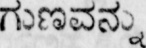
ಗುಣವನ್ನು
